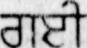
ਗਈ
